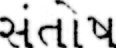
સંતોષ
